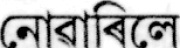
নোৱাৰিলে
